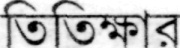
তিতিক্ষার
